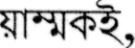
য়াম্মকই,
